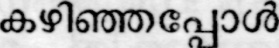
കഴിഞ്ഞപ്പോള്‍
